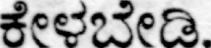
ಕೇಳಬೇಡಿ.
